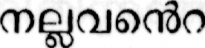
നല്ലവന്റെ
